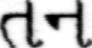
તન
